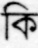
কি
